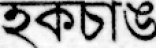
হকচাঙ
